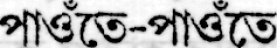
পাওঁতে-পাওঁতে
